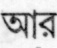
আর
